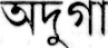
অদুগা
